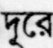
দূরে
